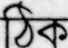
ঠিক
